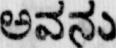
ಅವನು
